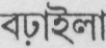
বঢ়াইলা
